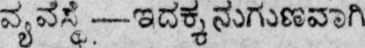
ವ್ಯವಸ್ಥೆ-ಇದಕ್ಕನುಗುಣವಾಗಿ
